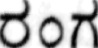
ರಂಗ
